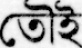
তৌই
